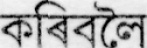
কৰিবলৈ
